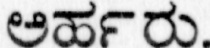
ಅರ್ಹರು.
